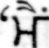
'ਮੈਂ
